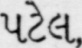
પટેલ,
